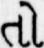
તો
